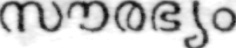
സൌരഭ്യം
